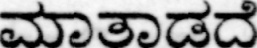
ಮಾತಾಡದೆ
